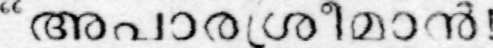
"അപാരശ്രീമാന്‍!
